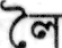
লৈ
